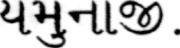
યમુનાજી.
